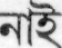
নাই
